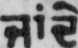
ਜਾਂਦੇ
